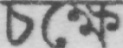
চক্ষে
